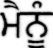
ਮੈਨੂੰ
